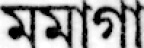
মমাগা
